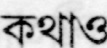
কথাও
